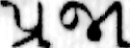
પ્રજા
